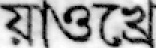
য়াওখ্রে
